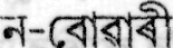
ন-বোৱাৰী
